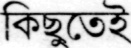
কিছুতেই
